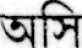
অসি
